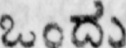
ಒಂದು
